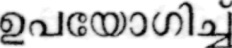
ഉപയോഗിച്ച്
